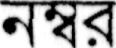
নম্বর
